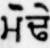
ਮੋਢੇ
